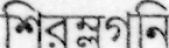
শিরম্লগনি
